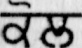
ਕੋਲ
